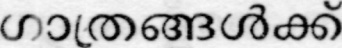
ഗാത്രങ്ങള്‍ക്ക്
